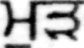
ਮੁੜ
